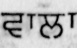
ਵਾਲਾ
